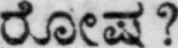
ರೋಷ?
